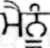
ਮੈਨੂੰ
